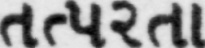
તત્પરતા
